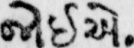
જોઈએ.
